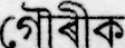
গৌৰীক
